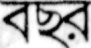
বছর
